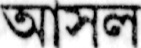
আসল
